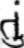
તું
